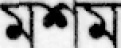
মশম
